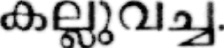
കല്ലുവച്ച.
